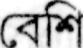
বেশি
